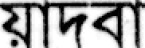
য়াদবা
